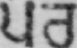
ਪਰ
